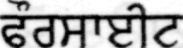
ਫੌਰਸਾਈਟ
